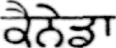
ਕੈਨੇਡਾ
